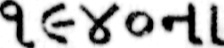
૧૯૪૦ના
